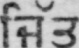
ਜਿੱਤ
